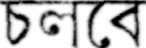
চলবে
